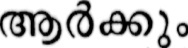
ആര്‍ക്കും
